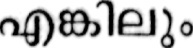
എങ്കിലും
